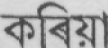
কৰিয়া
